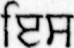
ਇਸ
